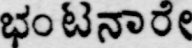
ಭಂಟನಾರೇ
